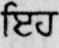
ਇਹ
